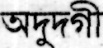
অদুদগী
